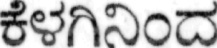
ಕೆಳಗಿನಿಂದ
